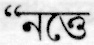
“নত্তে
